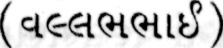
(વલ્લભભાઈ)
